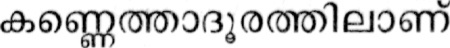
കണ്ണെത്താദൂരത്തിലാണ്
